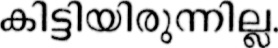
കിട്ടിയിരുന്നില്ല.
